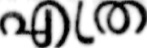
എത്ര
